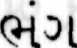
ભંગ
